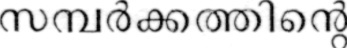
സമ്പര്‍ക്കത്തിന്റെ
